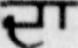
ਦਾ
